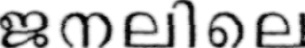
ജനലിലെ
